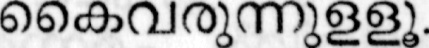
കൈവരുന്നുള്ളൂ.
